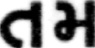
તમ
